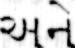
અને
